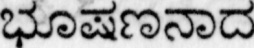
ಭೂಷಣನಾದ
